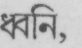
ধ্বনি,
